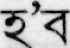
হ'ব
